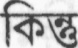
কিন্তু
